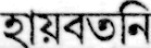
হায়বতনি
